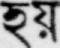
হয়
